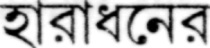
হারাধনের
